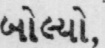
બોલ્યો,
